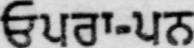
ਓਪਰਾ-ਪਨ
